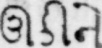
ઊઠીને
